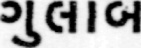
ગુલાબ
